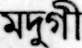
মদুগী
